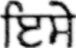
ਇਸੇ
